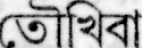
তৌখিবা
